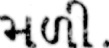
મળી.
